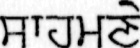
ਸਾਹਮਣੇ
